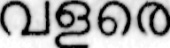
വളരെ
